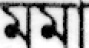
মমা
